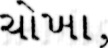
ચોખા,
